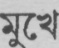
মুখে
